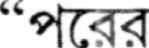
“পরের
